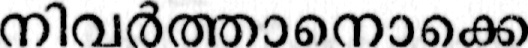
നിവര്‍ത്താനൊക്കെ
